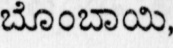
ಬೊಂಬಾಯಿ,
